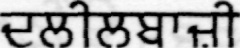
ਦਲੀਲਬਾਜ਼ੀ
